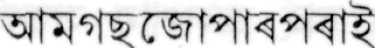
আমগছজোপাৰপৰাই
